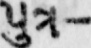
પુત્ર-
